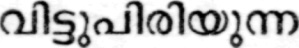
വിട്ടുപിരിയുന്ന
